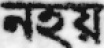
নহয়
